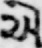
એ
